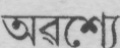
অৱশ্যে
